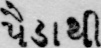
પૈડાથી
